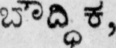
ಬೌದ್ಧಿಕ,
